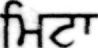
ਮਿਟਾ
